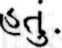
હતું.
